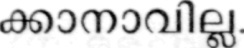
ക്കാനാവില്ല.
